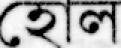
হোল
